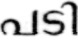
പടി
